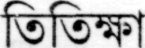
তিতিক্ষা
